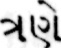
ત્રણે
